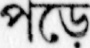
পড়ে
